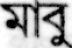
মাবু
